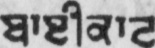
ਬਾਈਕਾਟ
